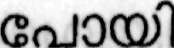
പോയി
